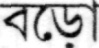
বড়ো
